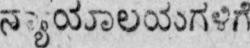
ನ್ಯಾಯಾಲಯಗಳಿಗೆ
